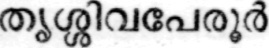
തൃശ്ശിവപേരൂര്‍
